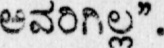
ಅವರಿಗಿಲ್ಲ”.
